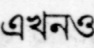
এখনও
